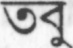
তবু
